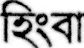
হিংবা
